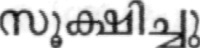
സൂക്ഷിച്ചു
